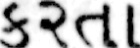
કરતા
